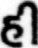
હી
